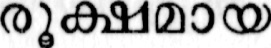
രൂക്ഷമായ
